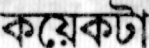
কয়েকটা
